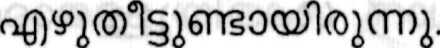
എഴുതീട്ടുണ്ടായിരുന്നു.
